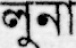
লুনা
